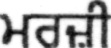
ਮਰਜ਼ੀ
